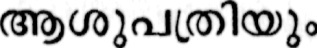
ആശുപത്രിയും
